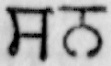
ਸਨ
